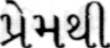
પ્રેમથી
